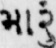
મારું
